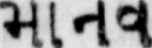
માનવ
